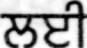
ਲਈ
